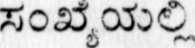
ಸಂಖ್ಯೆಯಲ್ಲಿ
